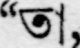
‘‘তা,
